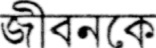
জীবনকে
